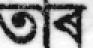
তাৰ
